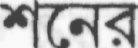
শনের
